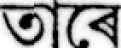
তাৰে
